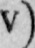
V)
